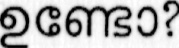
ഉണ്ടോ?
